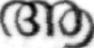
ആ
